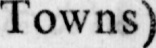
Towns)
